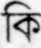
কি
